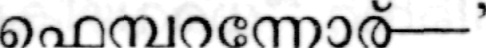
ഫെമ്പറന്നോര്-'
